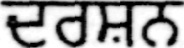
ਦਰਸ਼ਨ
